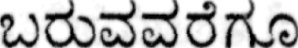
ಬರುವವರೆಗೂ
